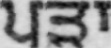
ਪੜਾ
